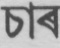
চাৰ
